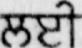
ਲਈ
